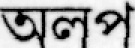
অলপ
